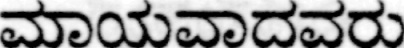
ಮಾಯವಾದವರು
